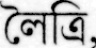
লৈত্রি,
